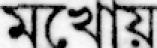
মখোয়
